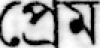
প্রেম
